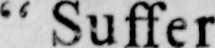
“Suffer
